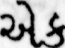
એક
